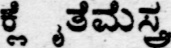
ಕ್ಲೈತೆಮೆಸ್ತ್ರ
